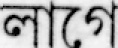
লাগে
